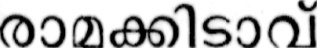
രാമക്കിടാവ്
